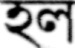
হল
